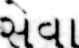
સેવા
